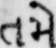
તમે
